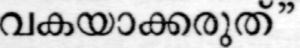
വകയാക്കരുത്”
